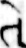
તે
